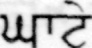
ਘਾਟੇ
